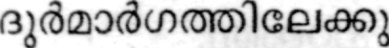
ദുര്‍മാര്‍ഗത്തിലേക്കു
